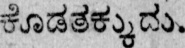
ಕೊಡತಕ್ಕುದು.
